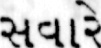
સવારે
